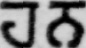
ਹਨ
